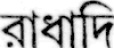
রাধাদি
